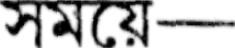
সময়ে-
